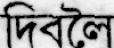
দিবলৈ
